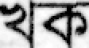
খক
